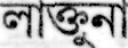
লাক্তুনা
